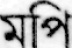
মপি
